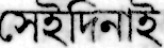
সেইদিনাই
